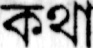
কথা
